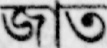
জাত
